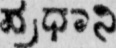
ಪ್ರಧಾನಿ
